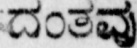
ದಂತವು
